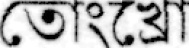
তোংখ্রো
